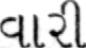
વારી
